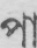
পা
